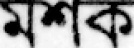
মশক
